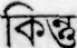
কিন্তু
